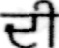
ਦੀ
